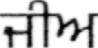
ਜੀਅ
